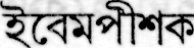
ইবেমপীশক
